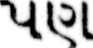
પણ
